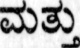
ಮತ್ತು
